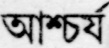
আশ্চর্য
